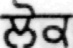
ਲੋਕ
